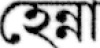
হেন্না
